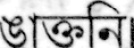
ঙাক্তনি।
